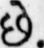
છે.
